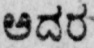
ಅದರ
